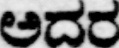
ಅದರ
